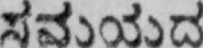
ಸಮಯದ
